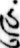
હું
